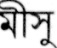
মীসু
